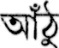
আঁঠু
